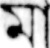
মা
